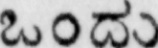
ಒಂದು
